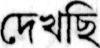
দেখছি
